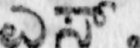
ಎಸ್.
